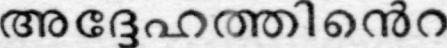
അദ്ദേഹത്തിന്റെ
